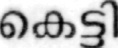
കെട്ടി
